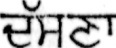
ਦੱਸਣਾ
